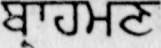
ਬ੍ਰਾਹਮਣ
